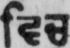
ਵਿਚ
